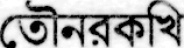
তৌনরকখি
